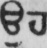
ਉਹ
